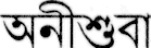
অনীশুবা
